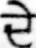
ਦੇ
